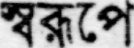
স্বরূপে
